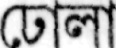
ঢোলা
